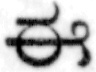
ಈ
